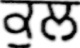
ਕੁਲ
